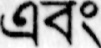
এবং
